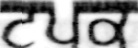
ਟਪਕ
